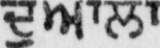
ਦੁਆਲਾ
